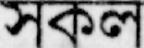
সকল
